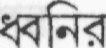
ধ্বনির
